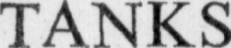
TANKS
